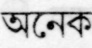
অনেক
